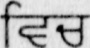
ਵਿਚ
